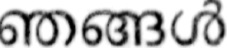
ഞങ്ങള്‍
